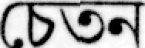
চেতন
